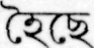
হৈছে
